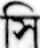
সি
